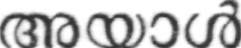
അയാള്‍
